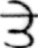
ਤੇ
